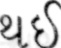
થઈ
